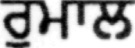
ਰੁਮਾਲ
